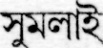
সুমলাই
